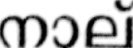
നാല്
